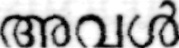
അവള്‍
